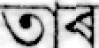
তাৰ
